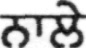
ਨਾਲੇ
